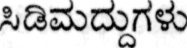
ಸಿಡಿಮದ್ದುಗಳು
